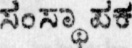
ಸಂಸ್ಥಾಪಕ
